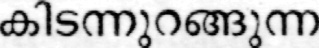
കിടന്നുറങ്ങുന്ന
